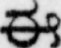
ಈ
